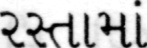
રસ્તામાં
